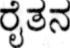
ರೈತನ
